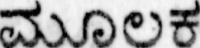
ಮೂಲಕ
